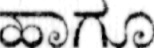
ಹಾಗೂ
